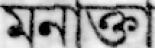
মনাক্তা
